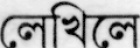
লেখিলে
